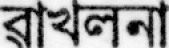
ৱাখলনা
